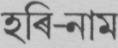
হৰি-নাম
